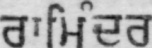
ਰਾਮਿੰਦਰ
